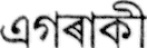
এগৰাকী
